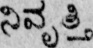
ನಿವೃತ್ತಿ
